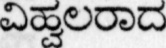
ವಿಹ್ವಲರಾದ
